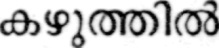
കഴുത്തില്‍
